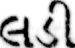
લડી
